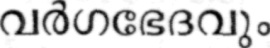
വര്‍ഗഭേദവും
